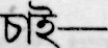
চাই-
